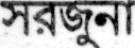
সরজুনা
